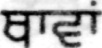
ਥਾਵਾਂ
